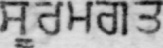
ਸੂਰਮਗਤ
